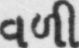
વળી
